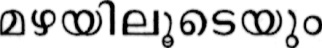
മഴയിലൂടെയും
